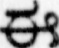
ಈ
